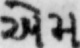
એમ
